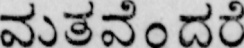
ಮತವೆಂದರೆ
